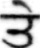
ਤੇ
